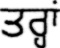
ਤਰ੍ਹਾਂ
